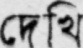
দেখি
